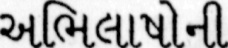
અભિલાષોની
